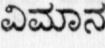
ವಿಮಾನ
